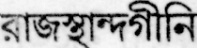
রাজস্থান্দগীনি
